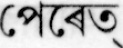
পেৰেত্
